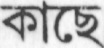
কাছে
